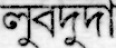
লুবদুদা
